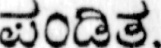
ಪಂಡಿತ.
